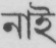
নাই
